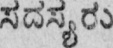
ಸದಸ್ಯರು
